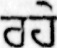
ਰਹੇ
